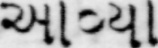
આવ્યા
